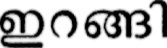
ഇറങ്ങി
